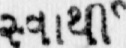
સ્વાર્થી
